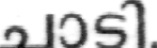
ചാടി.
